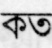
কত
